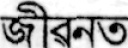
জীৱনত
